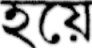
হয়ে
